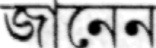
জানেন
